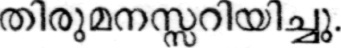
തിരുമനസ്സറിയിച്ചു.
